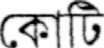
কোটি
